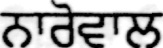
ਨਾਰੋਵਾਲ
